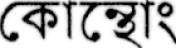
কোন্থোং
